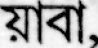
য়াবা,
